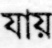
যায়
